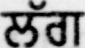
ਲੱਗ
